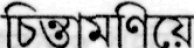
চিন্তামণিয়ে
